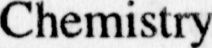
Chemistry
